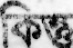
কিন্তু
